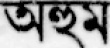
অহুম
